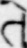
તે
